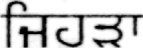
ਜਿਹੜਾ
